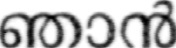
ഞാന്‍
